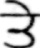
ਤੇ
